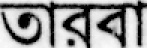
তারবা
